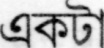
একটা
